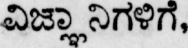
ವಿಜ್ಞಾನಿಗಳಿಗೆ,
